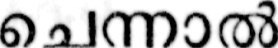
ചെന്നാല്‍
